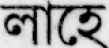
লাহে
